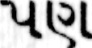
પણ
